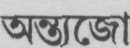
অন্ত্যজো
